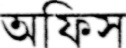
অফিস
